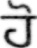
ਹੋ
